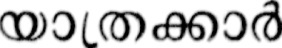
യാത്രക്കാര്‍
